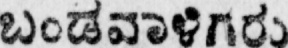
ಬಂಡವಾಳಿಗರು
